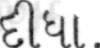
દીધા.
